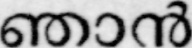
ഞാന്‍
